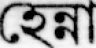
হেন্না
